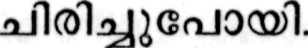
ചിരിച്ചുപോയി.
